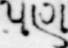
પણ
